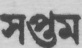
সপ্তম
